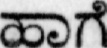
ಹಾಗೆ
